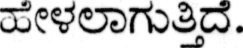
ಹೇಳಲಾಗುತ್ತಿದೆ.
